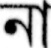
না
